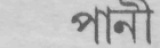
পানী
